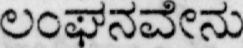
ಲಂಘನವೇನು
